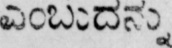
ಎಂಬುದನ್ನು
